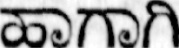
ಹಾಗಾಗಿ
